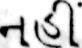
નહીં
